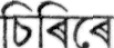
চিৰিৰে
